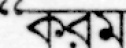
“করম
